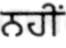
ਨਹੀਂ
